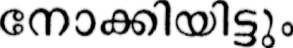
നോക്കിയിട്ടും
